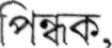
পিন্ধক,
